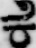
ಕೆ
